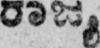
ರಾಜ್ಯ
